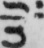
ਤੋਂ
